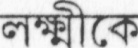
লক্ষ্মীকে
